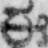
ಈ
